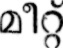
മീറ്റ്
